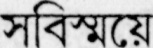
সবিস্ময়ে
